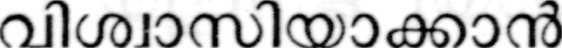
വിശ്വാസിയാക്കാന്‍
